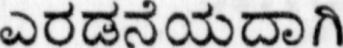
ಎರಡನೆಯದಾಗಿ
